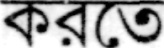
করতে
